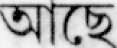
আছে
